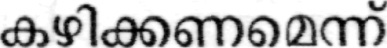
കഴിക്കണമെന്ന്
